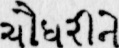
ચૌધરીને
